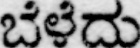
ಬೆಳೆದು
